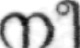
നീ
